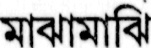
মাঝামাঝি
